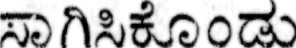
ಸಾಗಿಸಿಕೊಂಡು
